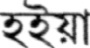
হইয়া
